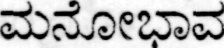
ಮನೋಭಾವ
